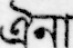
ঐনা
